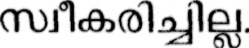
സ്വീകരിച്ചില്ല.
